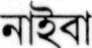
নাইবা
